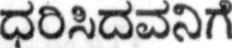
ಧರಿಸಿದವನಿಗೆ
